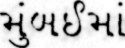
મુંબઈમાં
